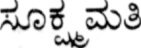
ಸೂಕ್ಷ್ಮಮತಿ
